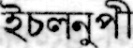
ইচলনুপী
